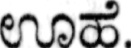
ಊಹೆ.
